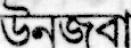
উনজবা
